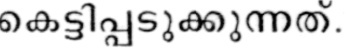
കെട്ടിപ്പടുക്കുന്നത്.
